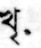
খৃ.
